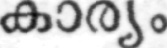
കാര്യം
